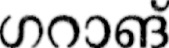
ഗറാങ്
